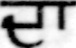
ਦਾ
